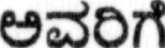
ಅವರಿಗೆ
